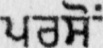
ਪਰਸੋਂ
